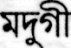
মদুগী
